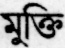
মুক্তি
